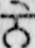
ਨੇ
